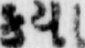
ક્યા
